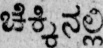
ಚೆಕ್ಕಿನಲ್ಲಿ
